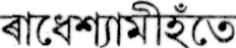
ৰাধেশ্যামীহঁতে
